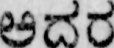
ಅದರ
